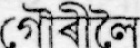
গৌৰীলৈ
